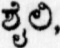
ಶೈಲಿ,
